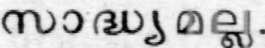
സാദ്ധ്യമല്ല.
